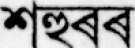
শহুৰৰ
